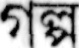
গল্প
